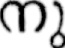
നു
